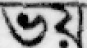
ভয়
